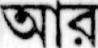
আর
